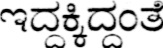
ಇದ್ದಕ್ಕಿದ್ದಂತೆ
